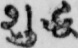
શુદ્ધ
